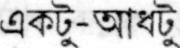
একটু-আধটু
